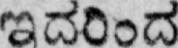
ಇದರಿಂದ
